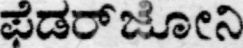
ಫೆಡರ್‌ಜೋನಿ
